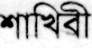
শাখিবী
